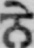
ਨੇ
